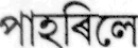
পাহৰিলে
